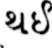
થઈ
